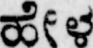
ಹೇಳ
